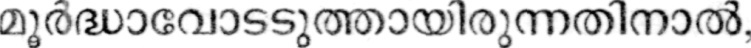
മൂര്‍ദ്ധാവോടടുത്തായിരുന്നതിനാല്‍,
